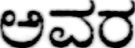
ಅವರ
